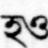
হও
